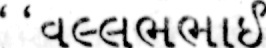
"વલ્લભભાઈ
